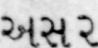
અસર
